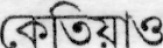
কেতিয়াও
